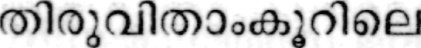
തിരുവിതാംകൂറിലെ
